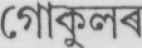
গোকুলৰ
